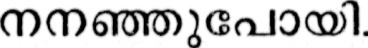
നനഞ്ഞുപോയി.
